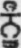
ਨੂੰ
